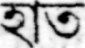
হাত
